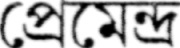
প্রেমেন্দ্র
